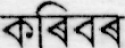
কৰিবৰ
